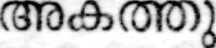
അകത്തു
